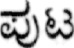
ಪುಟ
